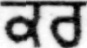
ਕਰ
